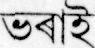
ভৰাই
